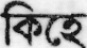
কিহে
